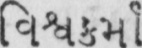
વિશ્વકર્મા
